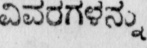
ವಿವರಗಳನ್ನು
